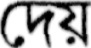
দেয়
